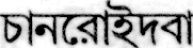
চানরোইদবা
